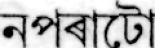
নপৰাটো
